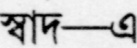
স্বাদ–এ
